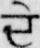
ਦੇ
